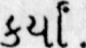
કર્યાં.
